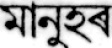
মানুহৰ
